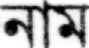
নাম
